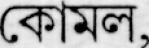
কোমল,
